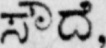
ಸೌದೆ,
